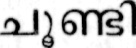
ചൂണ്ടി
